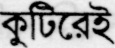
কুটিরেই
